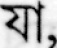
যা,
